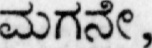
ಮಗನೇ,
